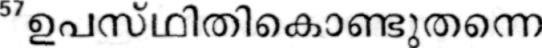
57ഉപസ്ഥിതികൊണ്ടുതന്നെ
